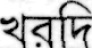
খরদি
